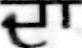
ਦਾ
